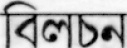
বিলচন
